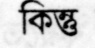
কিন্তু
